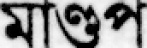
মাণ্ডপ
